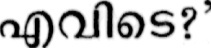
എവിടെ?’
